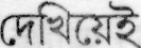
দেখিয়েই
